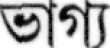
ভাগ্য
